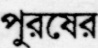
পুরুষের
